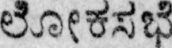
ಲೋಕಸಭೆ
